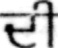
ਦੀ
